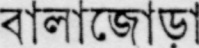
বালাজোড়া
